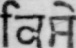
ਕਿਸੇ
